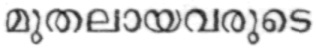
മുതലായവരുടെ
